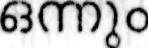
ഒന്നും
